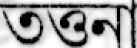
তত্তনা
